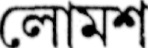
লোমশ
